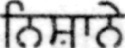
ਨਿਸ਼ਾਨੇ
